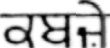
ਕਬਜ਼ੇ
